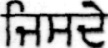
ਜਿਸਦੇ
